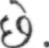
છે.
